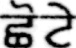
ਛੋਟੇ
